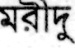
মরীদু
